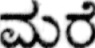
ಮರೆ
